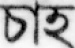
চাহ
